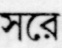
সরে
